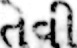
તેવી
